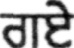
ਗਏ
